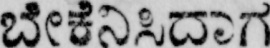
ಬೇಕೆನಿಸಿದಾಗ
